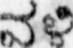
ವಳಿ
